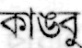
কাঙবু
